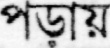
পড়ায়
